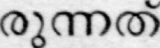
രുന്നത്
